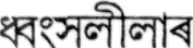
ধ্বংসলীলাৰ
